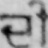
ਦੀ
